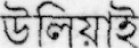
উলিয়াই
